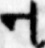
ન
